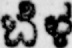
ಬೆಳ
